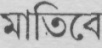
মাতিবে
